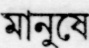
মানুষে
